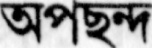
অপছন্দ
